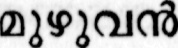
മുഴുവന്‍
